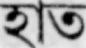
হাত
